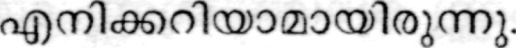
എനിക്കറിയാമായിരുന്നു.
